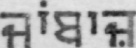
ਜਾਂਬਾਜ਼
